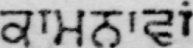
ਕਾਮਨਾਵਾਂ
